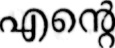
എന്റെ
